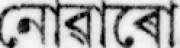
নোৱাৰো
